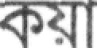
কয়া
